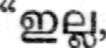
“ഇല്ല,
